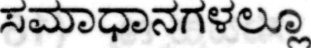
ಸಮಾಧಾನಗಳಲ್ಲೂ
